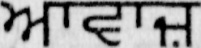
ਆਵਾਜ਼
